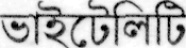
ভাইটেলিটি
